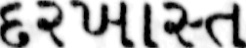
દરખાસ્ત
